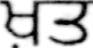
ਖ਼ਤ
